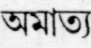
অমাত্য
